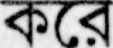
করে
